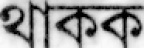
থাকক
